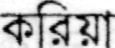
করিয়া
